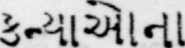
કન્યાઓના
